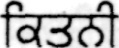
ਕਿਤਨੀ
